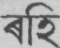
ৰহি
